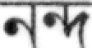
নন্দ
